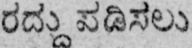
ರದ್ದುಪಡಿಸಲು
